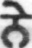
ਨੇ
